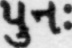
પુનઃ
